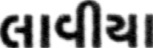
લાવીયા
